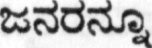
ಜನರನ್ನೂ
